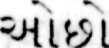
ઓછો
